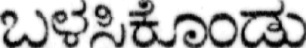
ಬಳಸಿಕೊಂಡು
